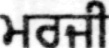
ਮਰਜੀ
